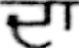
ਦਾ
